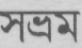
সভ্রম
